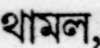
থামল,
